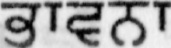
ਭਾਵਨਾ
